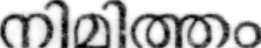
നിമിത്തം
